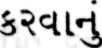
કરવાનું
